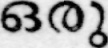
ഒരു
